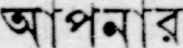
আপনার
